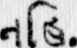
નહિ.
